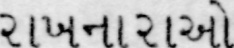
રાખનારાઓ
